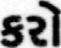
કરો
